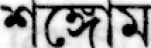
শঙ্গোম
